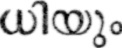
ധിയും
